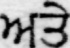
ਅਤੇ
